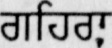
ਗਹਿਰਾ
